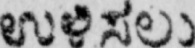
ಉಳಿಸಲು
